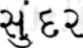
સુંદર
